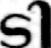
ടി
